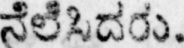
ನೆಲೆಸಿದರು.
